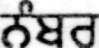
ਨੰਬਰ
